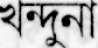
খন্দুনা
